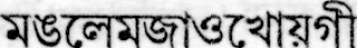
মঙলেমজাওখোয়গী
